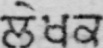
ਲੇਖਕ
